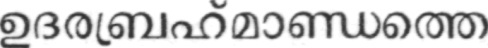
ഉദരബ്രഹ്മാണ്ഡത്തെ
